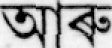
আৰু
